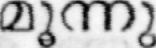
മൂന്നു
